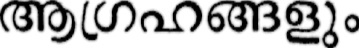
ആഗ്രഹങ്ങളും
